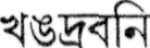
খঙদ্রবনি
